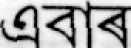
এবাৰ
